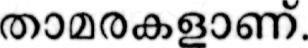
താമരകളാണ്.
